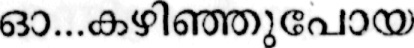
ഓ...കഴിഞ്ഞുപോയ
